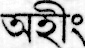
অহীং
